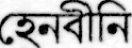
হেনবীনি
